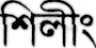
শিলীং
